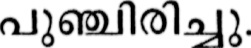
പുഞ്ചിരിച്ചു.
